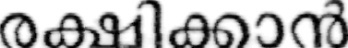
രക്ഷിക്കാന്‍
